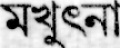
মখুৎনা
